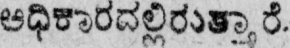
ಅಧಿಕಾರದಲಿರುತ್ತಾರೆ.
